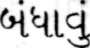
બંધાવું
